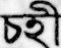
চহী
